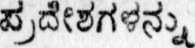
ಪ್ರದೇಶಗಳನ್ನು
